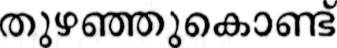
തുഴഞ്ഞുകൊണ്ട്
